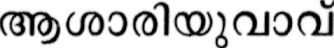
ആശാരിയുവാവ്
